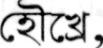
হৌখ্রে,
